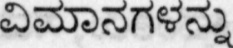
ವಿಮಾನಗಳನ್ನು
